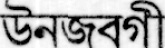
উনজবগী
